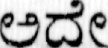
ಅದೇ
